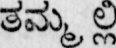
ತಮ್ಮಲ್ಲಿ
